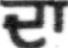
ਦਾ
